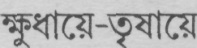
ক্ষুধায়ে-তৃষায়ে
